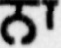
ਨਾ
